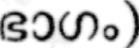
ഭാഗം)
